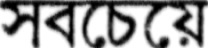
সবচেয়ে
